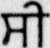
ਸੀ
